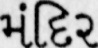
મંદિર
